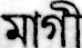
মাগী
